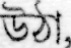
উঠা,
